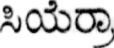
ಸಿಯೆರ್ರಾ
